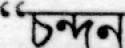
"চন্দন
